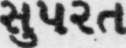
સુપરત
